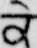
ਕੇ
